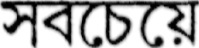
সবচেয়ে
